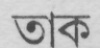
তাক
